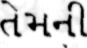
તેમની
